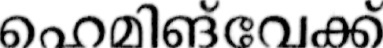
ഹെമിങ്വേക്ക്
